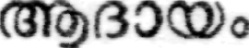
ആദായം
